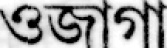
ওজাগা
